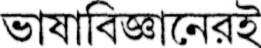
ভাষাবিজ্ঞানেরই
